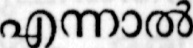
എന്നാല്‍
